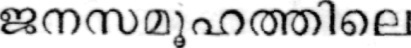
ജനസമൂഹത്തിലെ
